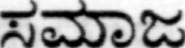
ಸಮಾಜ
